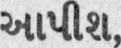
આપીશ,
